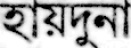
হায়দুনা
